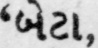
'બેટા,
